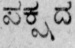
ಪಕ್ಪದ
